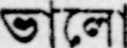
ভালো
